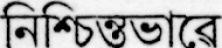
নিশ্চিন্তভাৱে
